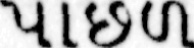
પાછળ
